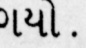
ગયો.
